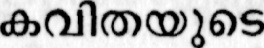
കവിതയുടെ
